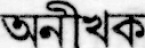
অনীখক
